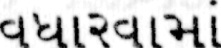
વધારવામાં
